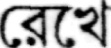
রেখে
